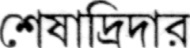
শেষাদ্রিদার
